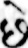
છે
